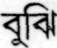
বুঝি
